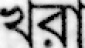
খরা
